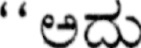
"ಅದು
